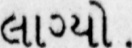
લાગ્યો.
